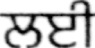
ਲਈ
